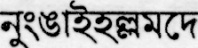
নুংঙাইহল্লমদে
